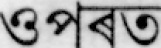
ওপৰত
